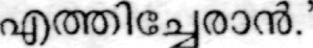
എത്തിച്ചേരാന്‍.’
